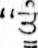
''ਤੂੰ
